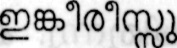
ഇങ്കീരീസ്സു
